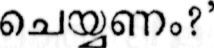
ചെയ്യണം?’
